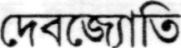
দেবজ্যোতি
